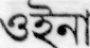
ওইনা
